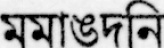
মমাঙদনি
